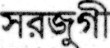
সরজুগী
